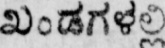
ಖಂಡಗಳಲ್ಲಿ
